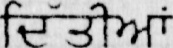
ਦਿੱਤੀਆਂ
